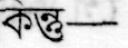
কিন্তু-
